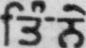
ਤਿੰਨੇ
